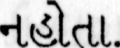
નહોતા.
